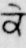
ਕੇ
